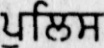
ਪੁਲਿਸ
